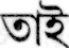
তাই
